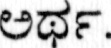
ಅರ್ಥ.
